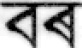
বৰ
